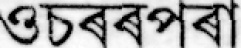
ওচৰৰপৰা
